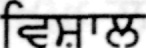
ਵਿਸ਼ਾਲ
